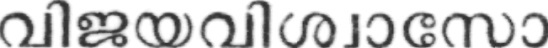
വിജയവിശ്വാസോ
